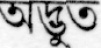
অদ্ভুত
